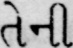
તેની
